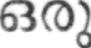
ഒരു
